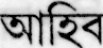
আহিব
